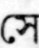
সে
